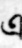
এ
